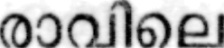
രാവിലെ
